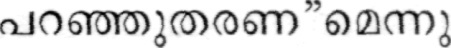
പറഞ്ഞുതരണ”മെന്നു
